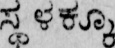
ಸ್ಥಳಕ್ಕೂ
